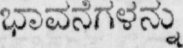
ಭಾವನೆಗಳನ್ನು
